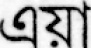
এয়া
